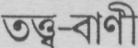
তত্ত্ব-বাণী
